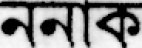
ননাক
